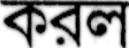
করল
